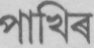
পাখিৰ
